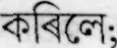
কৰিলে;
